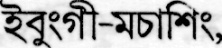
ইবুংগী-মচাশিং,
